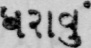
ધરાવું
